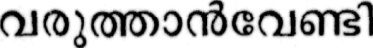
വരുത്താന്‍വേണ്ടി
